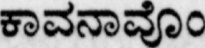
ಕಾವನಾವೊಂ
